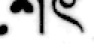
শেৎ
